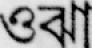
ওঝা
